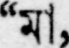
‘‘মা,
